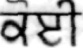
ਕੋਈ
